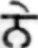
ਨੇ
